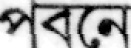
পবনে
